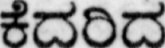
ಕೆದರಿದ
